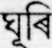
ঘূৰি
